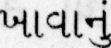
ખાવાનું
